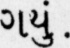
ગયું.
